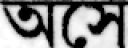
অসে
